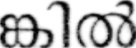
ങ്കില്‍
